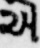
એ
